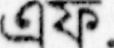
এফ.
